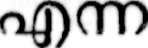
എന്ന
